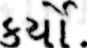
કર્યો.
